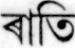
ৰাতি
